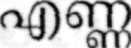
എണ്ണ
